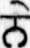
ਨੇ
